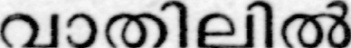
വാതിലില്‍
